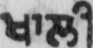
ਖਾਲੀ
